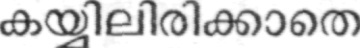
കയ്യിലിരിക്കാതെ
